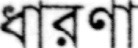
ধারণা
